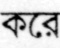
করে
